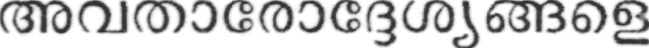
അവതാരോദ്ദേശ്യങ്ങളെ
